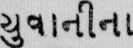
યુવાનીના
